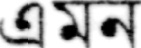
এমন
